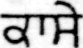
ਕਾਸੇ
